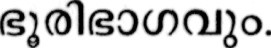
ഭൂരിഭാഗവും.
